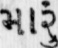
મારું
